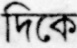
দিকে
